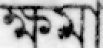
ক্ষমা
